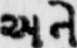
અને
